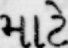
માટે
